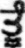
ਤੂੰ
